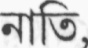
নাতি,
